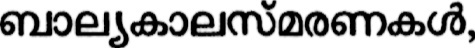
ബാല്യകാലസ്മരണകള്‍,
